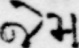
જેમ
